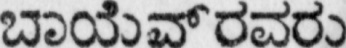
ಬಾಯೆವ್ರವರು
